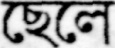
ছেলে
